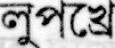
লুপখ্রে
